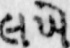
લખે
